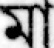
মা
